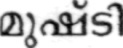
മുഷ്ടി
